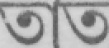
তাত
